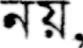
নয়,
